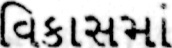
વિકાસમાં
